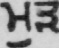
ਮੁੜ
